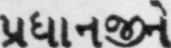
પ્રધાનજીને
